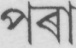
পৰা
